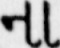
ના
